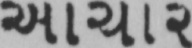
આચાર
